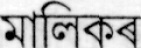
মালিকৰ
